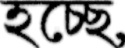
হচ্ছে,
